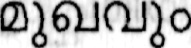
മുഖവും
